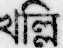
খল্লি
